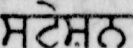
ਸਟੇਸ਼ਨ
